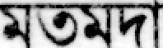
মতমদা
